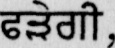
ਫੜੇਗੀ,
